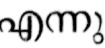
എന്നു
